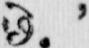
છે.'
